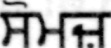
ਸੋਮਜ਼
